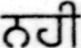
ਨਹੀ
